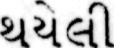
થયેલી
